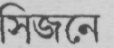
সিজনে
